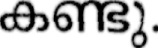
കണ്ടു.
